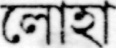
লোহা
